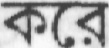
করে
